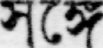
সঙ্গে
